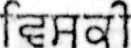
ਵਿਸਕੀ
